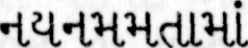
નયનમમતામાં
